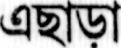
এছাড়া
